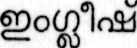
ഇംഗ്ലീഷ്
